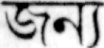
জন্য
